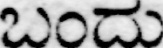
ಬಂದು
